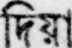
দিয়া
